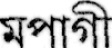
মপাগী
